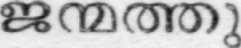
ജന്മത്തു
